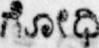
ಗೋಧಿ
